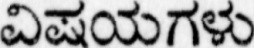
ವಿಷಯಗಳು
